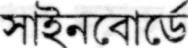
সাইনবোর্ডে
